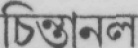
চিন্তানল
